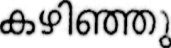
കഴിഞ്ഞു
